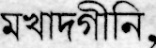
মখাদগীনি,
